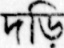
দড়ি
